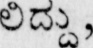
ಲಿದ್ದು,
